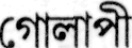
গোলাপী
